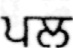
ਪਲ
